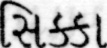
સિક્કા
